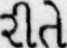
રીતે
